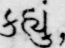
કહ્યું,
